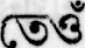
তেওঁ
